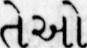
તેઓ
